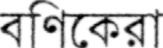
বণিকেরা
